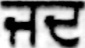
ਜਦ
